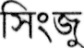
সিংজু
